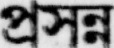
প্রসন্ন
